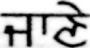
ਜਾਣੇ
